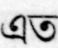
এত
